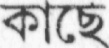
কাছে
